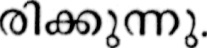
രിക്കുന്നു.
